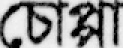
চোপ্পা
